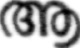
ആ
